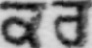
ਕਰ
